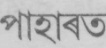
পাহাৰত
